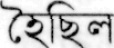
হৈছিল
